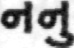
નનુ
